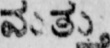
ಮತ್ತು
